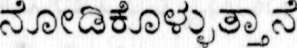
ನೋಡಿಕೊಳ್ಳುತ್ತಾನೆ
